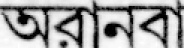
অরানবা
